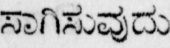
ಸಾಗಿಸುವುದು
